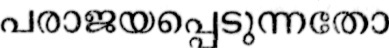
പരാജയപ്പെടുന്നതോ
